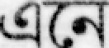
এনে
